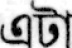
এটা
